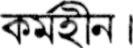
কর্মহীন।
